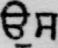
ਉਸ
